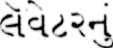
લૅવેટરનું
